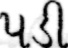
પડી
